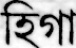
হিগা
